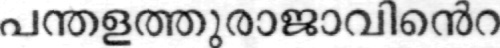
പന്തളത്തുരാജാവിന്റെ
